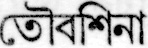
তৌবশিনা
